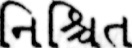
નિશ્ચિત
